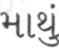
માથું
